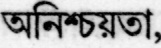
অনিশ্চয়তা,
